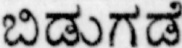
ಬಿಡುಗಡೆ
